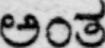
ಅಂತ
